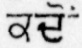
ਕਦੋਂ
